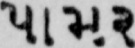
પામર
